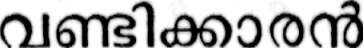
വണ്ടിക്കാരന്‍
